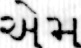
એમ
